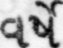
વર્ષે
